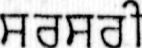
ਸਰਸਰੀ
